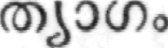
ത്യാഗം
